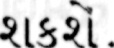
શકશે.
